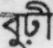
বুঢ়ী
